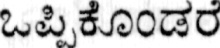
ಒಪ್ಪಿಕೊಂಡರೆ
